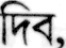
দিব,
